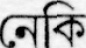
নেকি
